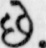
છે.
